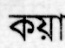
কয়া
